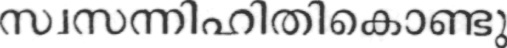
സ്വസന്നിഹിതികൊണ്ടു
